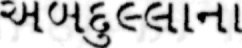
અબદુલ્લાના
